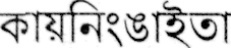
কায়নিংঙাইতা
